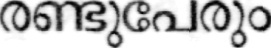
രണ്ടുപേരും
